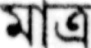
মাত্র
